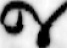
જ
